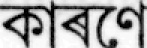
কাৰণে
